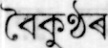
বৈকুণ্ঠৰ
